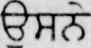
ਉਸਨੇ
